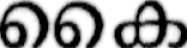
കൈ
